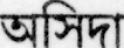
অসিদা
